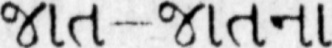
જાત-જાતના
